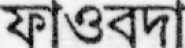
ফাওবদা
